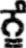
ਨੂੰ
